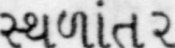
સ્થળાંતર
